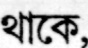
থাকে,
